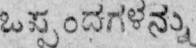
ಒಪ್ಪಂದಗಳನ್ನು
